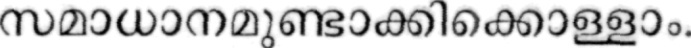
സമാധാനമുണ്ടാക്കിക്കൊള്ളാം.
